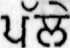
ਪੱਲੇ
